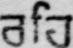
ਰਹਿ
